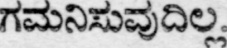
ಗಮನಿಸುವುದಿಲ್ಲ.
